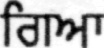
ਗਿਆ
